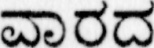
ವಾರದ
